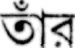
তাঁর
